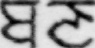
ਬਣ
